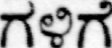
ಗಳಿಗೆ
